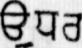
ਉਧਰ
